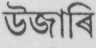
উজাৰি
